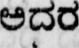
ಅದರ
